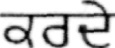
ਕਰਦੇ
